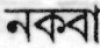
নকবা
